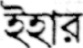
ইহার
